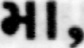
મા,
